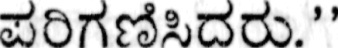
ಪರಿಗಣಿಸಿದರು."
